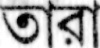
তারা
